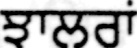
ਝਾਲਰਾਂ
